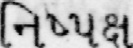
નિષ્પક્ષ
